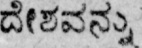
ದೇಶವನ್ನು
